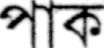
পাক
